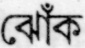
ঝোঁক
